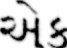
એક
